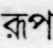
রূপ
